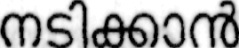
നടിക്കാന്‍
